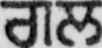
ਗਲ
